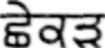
ਛੇਕੜ
